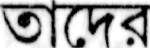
তাদের
